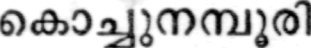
കൊച്ചുനമ്പൂരി
